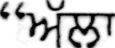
''ਅੱਲਾ
